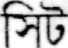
সিট
